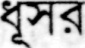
ধূসর
